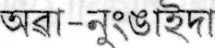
অৱা-নুংঙাইদা
